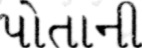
પોતાની
